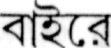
বাইরে
